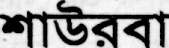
শাউরবা
